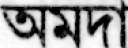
অমদা
